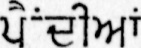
ਪੈਂਦੀਆਂ
